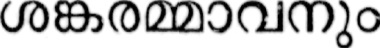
ശങ്കരമ്മാവനും
